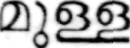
മുള്ള
